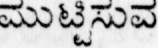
ಮುಟ್ಟಿಸುವ
